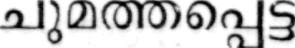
ചുമത്തപ്പെട്ട
